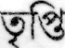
তৃপ্তি
